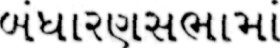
બંધારણસભામાં
